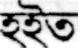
হইত
